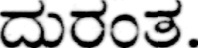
ದುರಂತ.
